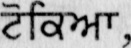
ਟੋਕਿਆ,
